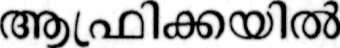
ആഫ്രിക്കയില്‍
